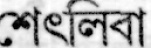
শেৎলিবা
